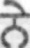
ਨੇ
